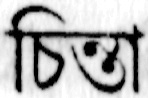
চিন্তা
